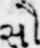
સૌ
